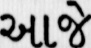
આજે
